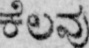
ಕೆಲವು
